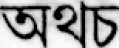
অথচ
